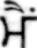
ਮੈਂ
